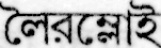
লৈরম্লোই
